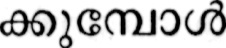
ക്കുമ്പോള്‍
